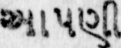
આપણી
